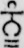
ਨੂੰ
